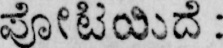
ಪೋಟಿಯಿದೆ:
